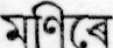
মণিৰে
